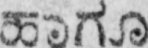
ಹಾಗೂ
